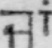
ਜਾਂ
